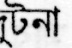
দুটনা
